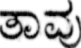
ತಾವು
